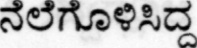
ನೆಲೆಗೊಳಿಸಿದ್ದ
